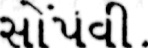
સોંપવી.
